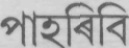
পাহৰিবি
